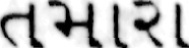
તમારા
